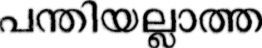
പന്തിയല്ലാത്ത
